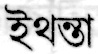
ইথন্তা
